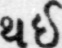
થઈ
